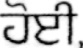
ਹੋਈ,
